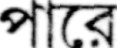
পারে
